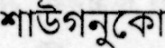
শাউগনুকো
